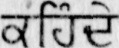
ਕਹਿੰਦੇ
